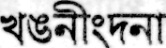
খঙনীংদনা
